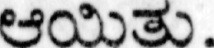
ಆಯಿತು.
